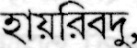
হায়রিবদু,
